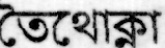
তৈথোক্না
